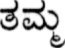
ತಮ್ಮ
